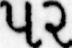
પર
